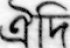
ঐদি
